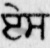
ਏਸ
